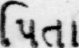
પિતા
